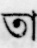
তা
